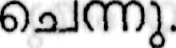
ചെന്നു.
